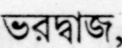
ভরদ্বাজ,
